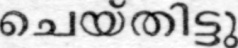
ചെയ്തിട്ടു
